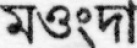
মওংদা
